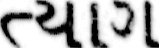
ત્યાગ
